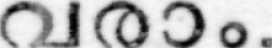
വരാം.
